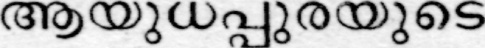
ആയുധപ്പുരയുടെ
